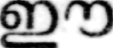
ഈ
